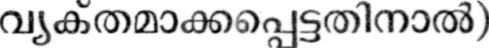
വ്യക്തമാക്കപ്പെട്ടതിനാല്‍)
